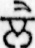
ਲੈ
